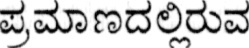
ಪ್ರಮಾಣದಲ್ಲಿರುವ
